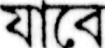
যাবে
